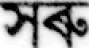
সৰু
